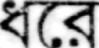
ধরে
